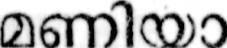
മണിയാ
